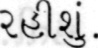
રહીશું.
